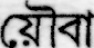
য়ৌবা
